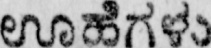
ಊಹೆಗಳು
